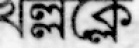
খল্লক্লে
